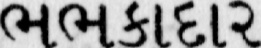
ભભકાદાર
